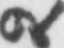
જ
